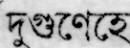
দুগুণেহে
